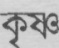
কৃষ্ণ
